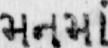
મનમાં
